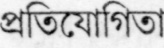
প্রতিযোগিতা
